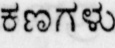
ಕಣಗಳು
